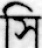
সি
